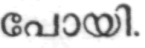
പോയി.
